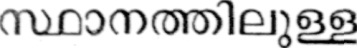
സ്ഥാനത്തിലുള്ള
